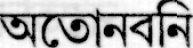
অতোনবনি
